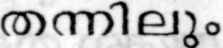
തന്നിലും
